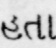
હતા
